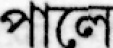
পালে
